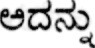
ಅದನ್ನು
